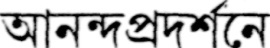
আদন্দপ্রদর্শনে
